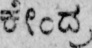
ಕೇಂದ್ರ
